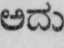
ಅದು
